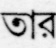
তার
